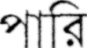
পারি
